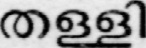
തള്ളി
